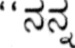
"ನನ್ನ
